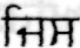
ਜਿਸ
